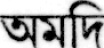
অমদি
